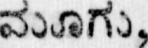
ಮೂಗು,
